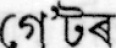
গে'টৰ
